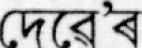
দেৱে'ৰ
